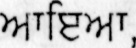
ਆਇਆ,
